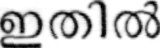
ഇതില്‍
